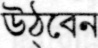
উঠ্বেন
